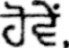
ਹੋਵੇਂ,
